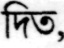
দিত,
